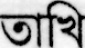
তাখি
